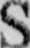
S
